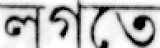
লগতে
